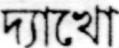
দ্যাখো
